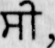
ਸੀ,
